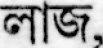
লাজ,
